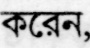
করেন,
